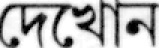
দেখোন
